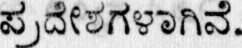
ಪ್ರದೇಶಗಳಾಗಿವೆ.
